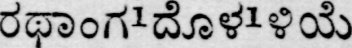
ರಥಾಂಗ1ದೊಳ1ಳಿಯೆ
